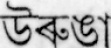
উৰুঙা
